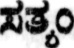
ಸತ್ಯ೦
